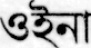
ওইনা
